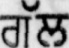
ਗੱਲ
